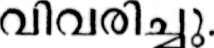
വിവരിച്ചു.
